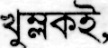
খুম্লকই,
